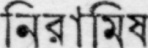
নিরামিষ
